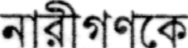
নারীগণকে
